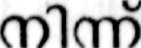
നിന്ന്
